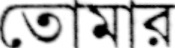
তোমার
